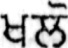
ਖਲੋ
